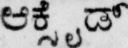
ಆಕ್ಸೈಡ್
